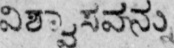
ವಿಶ್ವಾಸವನ್ನು
